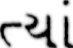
ત્યાં
